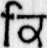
ਕਿ
